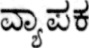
ವ್ಯಾಪಕ
